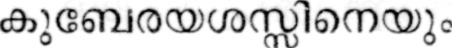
കുബേരയശസ്സിനെയും
